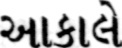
આકાલે
